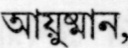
আয়ুষ্মান,
